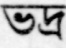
ভদ্র
